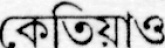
কেতিয়াও
